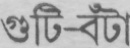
গুটি-বঁটা
